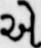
એ
